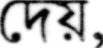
দেয়,
